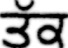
ਤੱਕ
